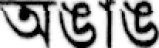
অঙাঙ
